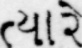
ત્યારે
